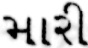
મારી
